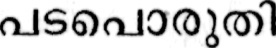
പടപൊരുതി
